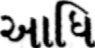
આધિ
